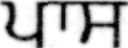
ਪਾਸ
